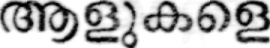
ആളുകളെ
